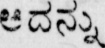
ಅದನ್ನು
